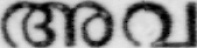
അവ
